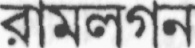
রামলগন
